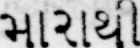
મારાથી
